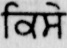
ਕਿਸੇ
